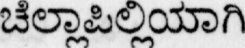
ಚೆಲ್ಲಾಪಿಲ್ಲಿಯಾಗಿ
